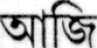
আজি
